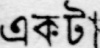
একটা
